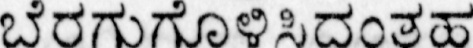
ಬೆರಗುಗೊಳಿಸಿದಂತಹ
